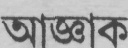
আজ্ঞাক
